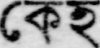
কেহ
